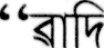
“ৱাদি
